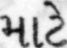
માટે
